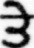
ਤੇ
